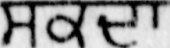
ਸਕਦਾ
